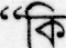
"কি
